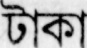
টাকা
